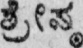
ಶ್ರೇಷ್ಠ
